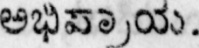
ಅಭಿಪ್ರಾಯ.
